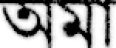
অমা
